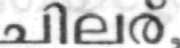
ചിലര്,
